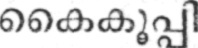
കൈകൂപ്പി
